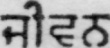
ਜੀਵਨ
